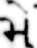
મેં
